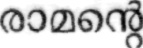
രാമന്റെ
